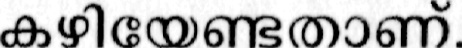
കഴിയേണ്ടതാണ്.
